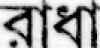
রাধা
